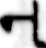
ન
